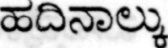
ಹದಿನಾಲ್ಕು
